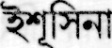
ইশূসিনা
